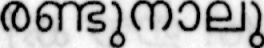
രണ്ടുനാലു
